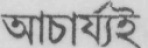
আচাৰ্য্যই
